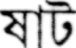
ষাট
